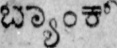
ಬ್ಯಾಂಕ್
